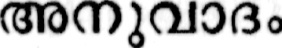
അനുവാദം
